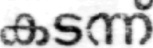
കടന്ന്
